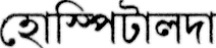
হোস্পিটালদা
